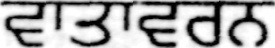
ਵਾਤਾਵਰਨ
